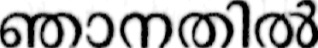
ഞാനതില്‍
